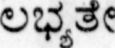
ಲಭ್ಯತೇ
